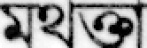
মথক্তা
